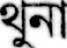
থুনা
